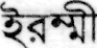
ইরম্মী
